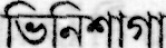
ভিনিশাগা
